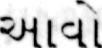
આવો
